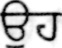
ਉਹ
